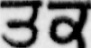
ਤਕ
